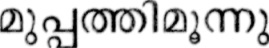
മുപ്പത്തിമൂന്നു
